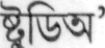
ষ্টুডিঅ'
